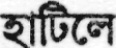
হাটিলে
